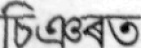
চিঞৰত
